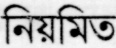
নিয়মিত
